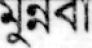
মুন্নবা
